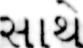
સાથે
